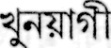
খুনয়াগী
